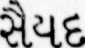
સૈયદ
